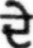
ਦੇ
